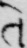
તે
